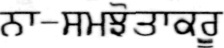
ਨਾ-ਸਮਝੋਤਾਕਰੂ
